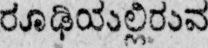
ರೂಢಿಯಲ್ಲಿರುವ
